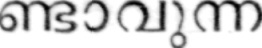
ണ്ടാവുന്ന
